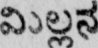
ಮಿಲ್ಲನ
